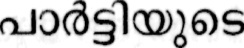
പാര്‍ട്ടിയുടെ
